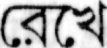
রেখে
